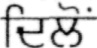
ਦਿਲੋਂ
